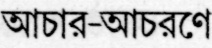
আচার-আচরণে
